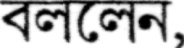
বললেন,
